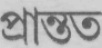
প্ৰান্তত
